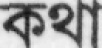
কথা
